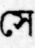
সে
